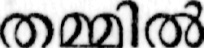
തമ്മില്‍
